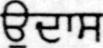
ਉਦਾਸ
